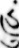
હું
